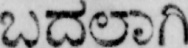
ಬದಲಾಗಿ
